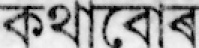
কথাবোৰ
